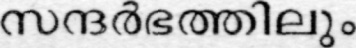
സന്ദര്‍ഭത്തിലും
